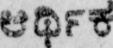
ಆರ್ಥಿಕ
